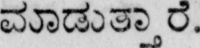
ಮಾಡುತ್ತಾರೆ.
